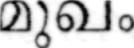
മുഖം
